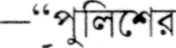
–“পুলিশের
